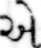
એ
